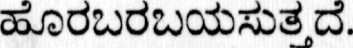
ಹೊರಬರಬಯಸುತ್ತದೆ.
